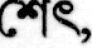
শেৎ,
